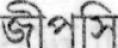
জীপসি
